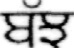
ਬੱਝ
